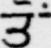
ਤੋਂ
